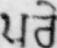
ਪਰੇ
